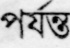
পর্যন্ত
